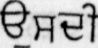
ਉਸਦੀ
